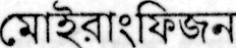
মোইরাংফিজন
